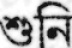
শুনি
